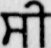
ਸੀ
